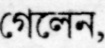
গেলেন,
